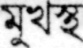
মুখস্থ
